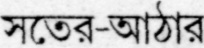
সতের-আঠার
